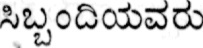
ಸಿಬ್ಬಂದಿಯವರು
